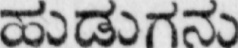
ಹುಡುಗನು
